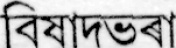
বিষাদভৰা
